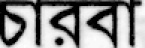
চারবা
